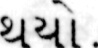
થયો.
